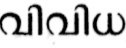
വിവിധ
